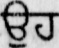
ਉਹ
